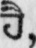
ਹੈ,
